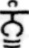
ਨੂੰ
